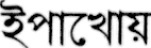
ইপাখোয়
